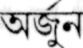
অর্জুন
